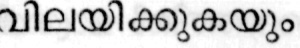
വിലയിക്കുകയും
